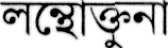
লান্থোক্তুনা
